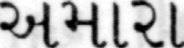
અમારા
